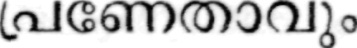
പ്രണേതാവും
